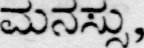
ಮನಸ್ಸು,
